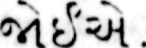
જોઈએ.
